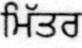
ਮਿੱਤਰ
